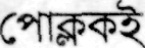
পোক্লকই
